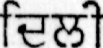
ਦਿਲੀ
